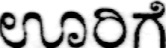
ಊರಿಗೆ
